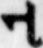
ન
